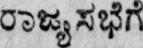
ರಾಜ್ಯಸಭೆಗೆ
